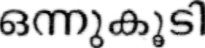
ഒന്നുകൂടി
